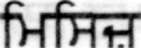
ਮਿਸਿਜ਼
